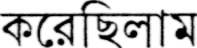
করেছিলাম
